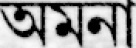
অমনা
